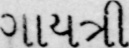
ગાયત્રી
